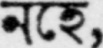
নহে,
